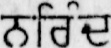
ਨਰਿੰਦ
